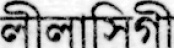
লীলাসিগী
